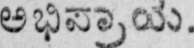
ಅಭಿಪ್ರಾಯ.
